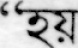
"হয়
